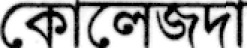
কোলেজদা
